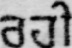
ਰਹੀ
